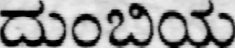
ದುಂಬಿಯ
